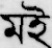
মই
